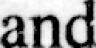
and
